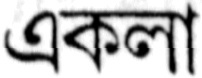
একলা
